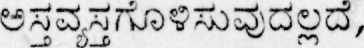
ಅಸ್ತವ್ಯಸ್ತಗೊಳಿಸುವುದಲ್ಲದೆ,
